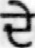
ਦੇ
